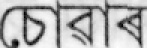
চোৱাৰ
